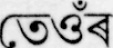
তেওঁৰ
